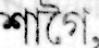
শাগৈ,
